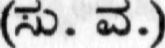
(ಸು.ವ.)
